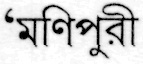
‘মণিপুরী
